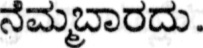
ನೆಮ್ಮಬಾರದು.
